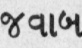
જવાબ
